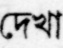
দেখা
